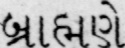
બ્રાહ્મણે
